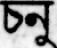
চনু
